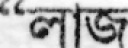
"লাজ
